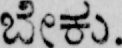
ಬೇಕು.
